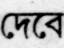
দেবে
